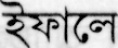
ইফালে
